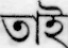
তাই
